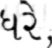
ધરે,
